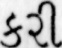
કરી
